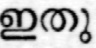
ഇതു
